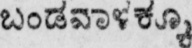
ಬಂಡವಾಳಕ್ಕೂ
